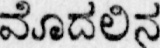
ಮೊದಲಿನ
